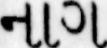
નાગ
